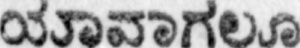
ಯಾವಾಗಲೂ
